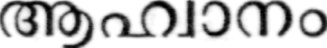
ആഹ്വാനം
